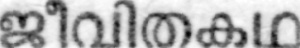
ജീവിതകഥ
